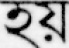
হয়
